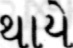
થાયે
